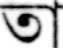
তা
